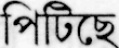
পিটিছে
